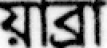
য়াব্রা
